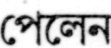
পেলেন
